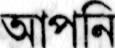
আপনি
